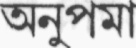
অনুপমা
